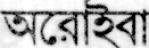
অরোইবা
